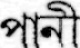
পানী
